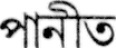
পানীত
